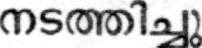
നടത്തിച്ചു
